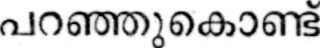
പറഞ്ഞുകൊണ്ട്
